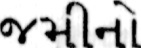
જમીનો
